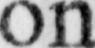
on
